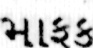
માફક
